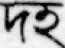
দহ
